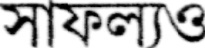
সাফল্যও
